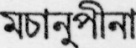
মচানুপীনা
